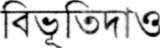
বিভূতিদাও
